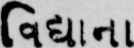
વિધાના
